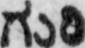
ಗುರಿ
